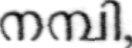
നമ്പി,
